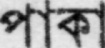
পাকা
